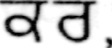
ਕਰ,
